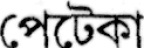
পেটেকা
